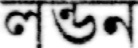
লন্ডন
